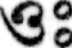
ওঃ
